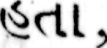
હતા,
